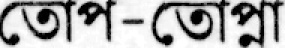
তোপ-তোপ্না
